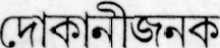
দোকানীজনক
